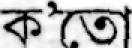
ক'তো
